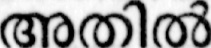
അതില്‍
